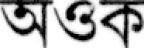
অওক
